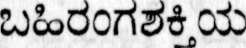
ಬಹಿರಂಗಶಕ್ತಿಯ
